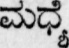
ಮಧ್ಯೆ
